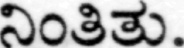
ನಿಂತಿತು.
